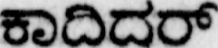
ಕಾದಿದರ್
